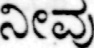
ನೀವು
